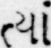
ત્યાં
